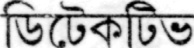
ডিটেকটিভ
